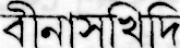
বীনাসখিদি
